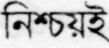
নিশ্চয়ই
